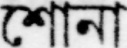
শোনা
